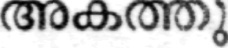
അകത്തു
